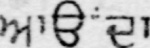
ਆਉਂਦਾ
